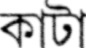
কাটা
